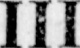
III
